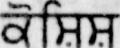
ਕੋਸ਼ਿਸ਼
